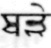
ਬੜੇ
